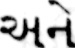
અને
